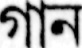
গান
